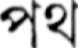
পথ
